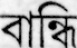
বান্ধি
